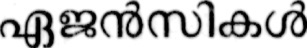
ഏജന്‍സികള്‍
